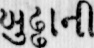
બુઢ્ઢાની
